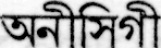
অনীসিগী
